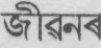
জীৱনৰ
